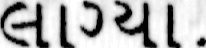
લાગ્યા.
